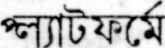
প্ল্যাটফর্মে
